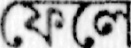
ফেলে
